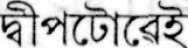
দ্বীপটোৱেই
